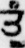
ਤੂੰ
